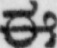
ಈ
